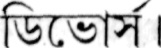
ডিভোর্স।
